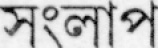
সংলাপ
